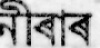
নীৰাৰ
